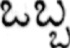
ಒಬ್ಬ
